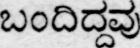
ಬಂದಿದ್ದವು
